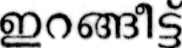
ഇറങ്ങീട്ട്
